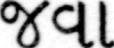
જવા
